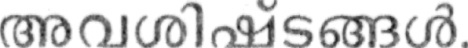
അവശിഷ്ടങ്ങള്‍.
